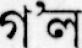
গ'ল
